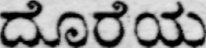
ದೊರೆಯ
